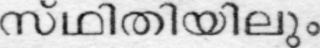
സ്ഥിതിയിലും
